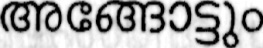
അങ്ങോട്ടും
